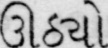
ઊઠ્યો
